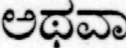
ಅಥವಾ
